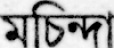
মচিন্দা
